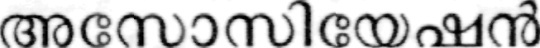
അസോസിയേഷന്‍
